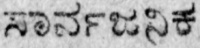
ಸಾರ್ವಜನಿಕ
